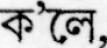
ক'লে,
